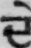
ਦੇ
